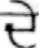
ਦੇ
